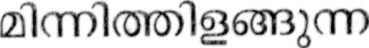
മിന്നിത്തിളങ്ങുന്ന
